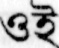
ওই
